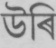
উৰি
